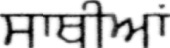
ਸਾਥੀਆਂ
